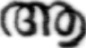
ആ
